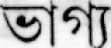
ভাগ্য
